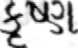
કૃષ્ણ
